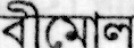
বীমোল
